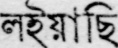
লইয়াছি
